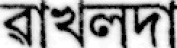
ৱাখলদা
